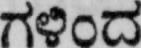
ಗಳಿಂದ
